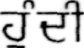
ਹੁੰਦੀ
